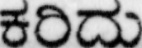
ಕರಿದು
